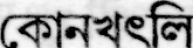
কোনখৎলি
